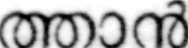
ത്താന്‍
